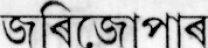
জৰিজোপাৰ
